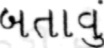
બતાવું
